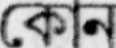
কোন
